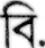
বি.
